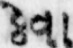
કેવા
